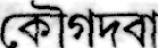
কৌগদবা
